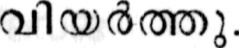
വിയര്‍ത്തു.
